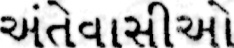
અંતેવાસીઓ
